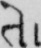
તો
